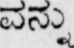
ವನ್ನು
